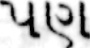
પણ
